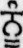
ਨੂੰ
